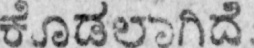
ಕೊಡಲಾಗಿದೆ.
